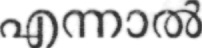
എന്നാല്‍
